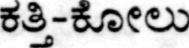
ಕತ್ತಿ-ಕೋಲು
